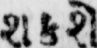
શકશે
